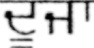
ਦੂਜਾ
